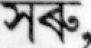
সৰু,
